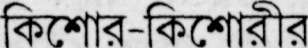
কিশোর-কিশোরীর
